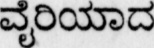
ವೈರಿಯಾದ
